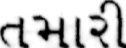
તમારી
